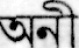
অনী
